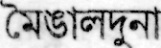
মৈঙালদুনা
